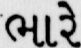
ભારે
